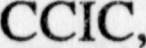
CCIC,
